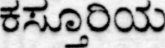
ಕಸ್ತೂರಿಯ
